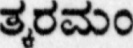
ತ್ಕರಮಂ
